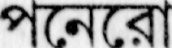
পনেরো
